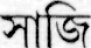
সাজি
